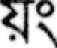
য়ং
